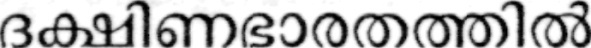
ദക്ഷിണഭാരതത്തില്‍
